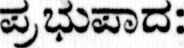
ಪ್ರಭುಪಾದ:
